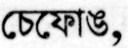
চেফোঙ,
